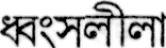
ধ্বংসলীলা
